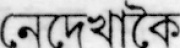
নেদেখাকৈ
